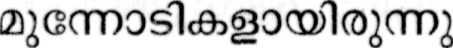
മുന്നോടികളായിരുന്നു
